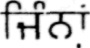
ਜਿੰਨਾਂ
